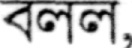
বলল,
